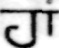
ਹਾਂ
